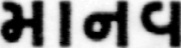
માનવ
